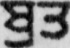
ਬੁਤ
